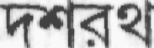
দশরথ
